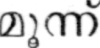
മൂന്ന്
